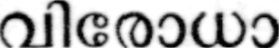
വിരോധാ
